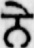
ਨੇ
